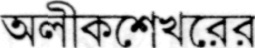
অলীকশেখরের
